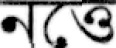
নত্তে
